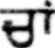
ਚਾਂ
